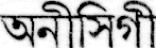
অনীসিগী
